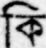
কি
